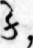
કે,
